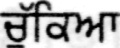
ਚੁੱਕਿਆ
